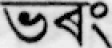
ভৰং
